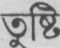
তুষ্টি
